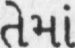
તેમાં
